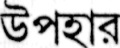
উপহার
